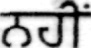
ਨਹੀਂ
